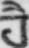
ਹੈ
